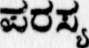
ಪರಸ್ಯ
